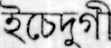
ইচেদুগী
